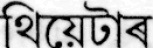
থিয়েটাৰ
